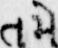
તમે
